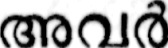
അവര്‍
